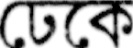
ঢেকে
